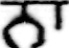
ਨਾ
